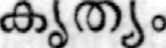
കൃത്യം
